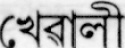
খেৱালী
